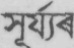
সূৰ্য্যৰ
